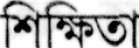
শিক্ষিতা
